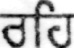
ਰਹਿ
